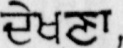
ਦੇਖਣਾ,
